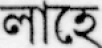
লাহে
